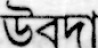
উবদা
